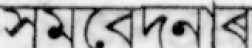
সমবেদনাৰ
